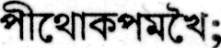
পীথোকপমখৈ;
